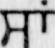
ਸਾਂ
